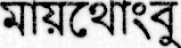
মায়থোংবু
